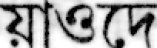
য়াওদে
